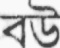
বউ
